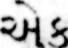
એક
